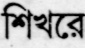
শিখরে
